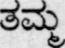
ತಮ್ಮ
